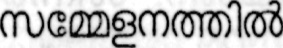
സമ്മേളനത്തില്‍
